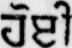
ਹੋਈ
